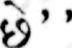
છે"
